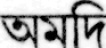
অমদি
